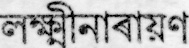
লক্ষ্মীনাৰায়ণ
